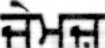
ਜੇਮਜ਼
